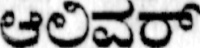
ಆಲಿವರ್
